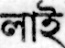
লাই
